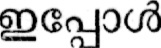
ഇപ്പോള്‍
